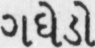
ગધેડો
